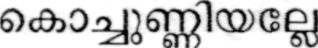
കൊച്ചുണ്ണിയല്ലേ
